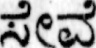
ಸೇವೆ
